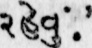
રહેવું.'
